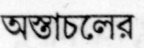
অস্তাচলের
